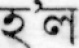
হ'ল
